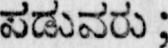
ಪಡುವರು;
